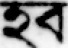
হব
